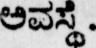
ಅವಸ್ಥೆ.
